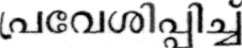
പ്രവേശിപ്പിച്ച്
